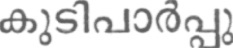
കുടിപാര്‍പ്പു
